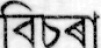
বিচৰা
